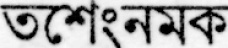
তশেংনমক
